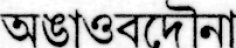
অঙাওবদৌনা
